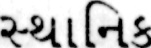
સ્થાનિક
